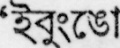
‘ইবুংঙো
